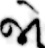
જો
